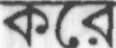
করে
